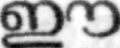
ഈ
